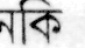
নকি
